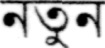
নতুন
